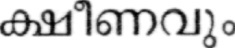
ക്ഷീണവും
